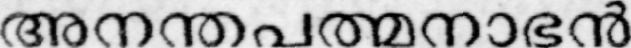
അനന്തപത്മനാഭന്‍
